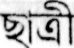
ছাত্রী
